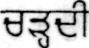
ਚੜ੍ਹਦੀ
